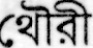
থৌরী
